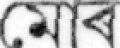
মোৰ
